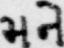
મને
